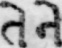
તેને
